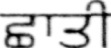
ਛਾਤੀ
